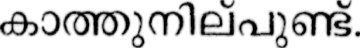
കാത്തുനില്പുണ്ട്.
